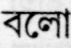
বলো
